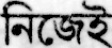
নিজেই
